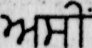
ਅਸੀਂ
